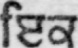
ਇਕ
